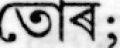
তোৰ;
